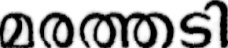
മരത്തടി
